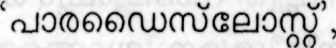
'പാരഡൈസ്ലോസ്റ്റ്',
